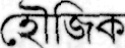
হৌজিক
